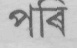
পৰি
